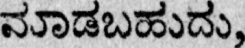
ಮಾಡಬಹುದು,
